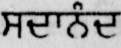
ਸਦਾਨੰਦ
